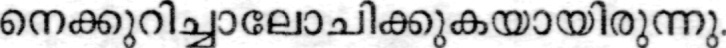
നെക്കുറിച്ചാലോചിക്കുകയായിരുന്നു.
